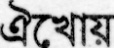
ঐখোয়
